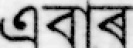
এবাৰ
